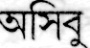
অসিবু
